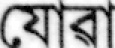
যোৱা
